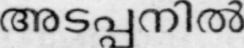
അടപ്പനില്‍
